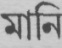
মানি
